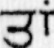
ਤਾਂ
